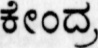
ಕೇಂದ್ರ
